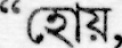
“হোয়,
